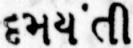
દમયંતી
